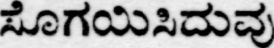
ಸೊಗಯಿಸಿದುವು
